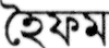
হৈফম
